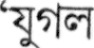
'যুগল
